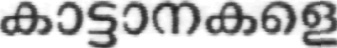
കാട്ടാനകളെ
